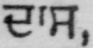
ਦਾਸ,
